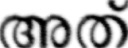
അത്
